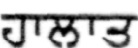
ਹਾਲਾਤ
